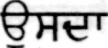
ਉਸਦਾ
